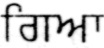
ਗਿਆ
